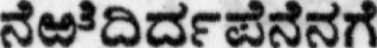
ನೆಱೆದಿರ್ದಪೆನೆನಗೆ
